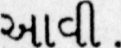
આવી.
